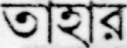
তাহার
